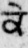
ਕੇ
